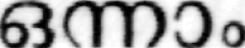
ഒന്നാം
